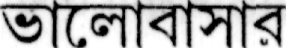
ভালোবাসার
